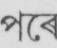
পৰে
